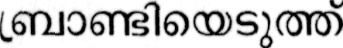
ബ്രാണ്ടിയെടുത്ത്
